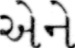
એને
